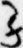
કે
